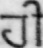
ਹੀ
